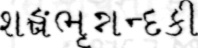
શહ્ભૃન્નન્દકી
